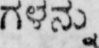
ಗಳನ್ನು
